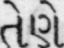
તેણે
